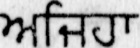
ਅਜਿਹਾ
